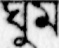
ঘুম
